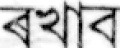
ৰখাব
